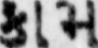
કામ
